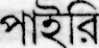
পাইরি
